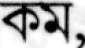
কম,
